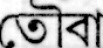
তৌবা
